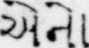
એનો
